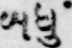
બધું
